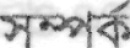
সম্পর্ক
